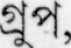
গ্রুপ,
